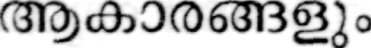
ആകാരങ്ങളും
